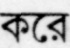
করে
